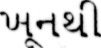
ખૂનથી
